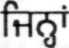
ਜਿਨ੍ਹਾਂ
